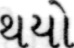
થયો
